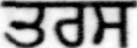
ਤਰਸ
